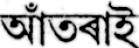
আঁতৰাই
